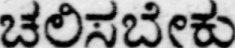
ಚಲಿಸಬೇಕು
